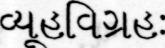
વ્યૂહવિગ્રહઃ
